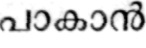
പാകാന്‍
